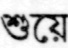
শুয়ে
